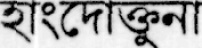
হাংদোক্তুনা
